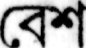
বেশ
